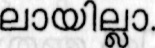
ലായില്ലാ.
